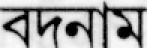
বদনাম
